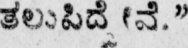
ತಲುಪಿದ್ದೇವೆ.”
